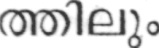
ത്തിലും
